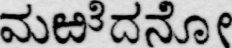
ಮಱೆದನೋ
